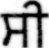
ਸੀ
